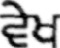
ਵੇਖ
